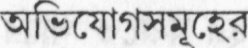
অভিযোগসমূহের
